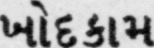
ખોદકામ
